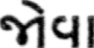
જોવા
